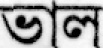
ভাল
